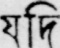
যদি
